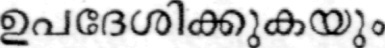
ഉപദേശിക്കുകയും
